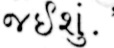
જઈશું.'
